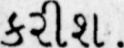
કરીશ.'
